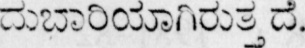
ದುಬಾರಿಯಾಗಿರುತ್ತದೆ.
